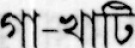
গা-খাটি
